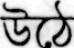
উঠে
